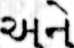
અને
